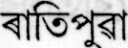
ৰাতিপুৱা
